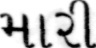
મારી
